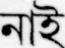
নাই
